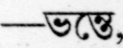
–ভন্তে,
